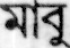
মাবু
